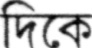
দিকে
